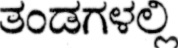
ತಂಡಗಳಲ್ಲಿ
